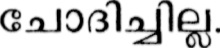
ചോദിച്ചില്ല.
